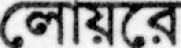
লোয়রে
